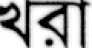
খরা
